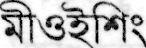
মীওইশিং
